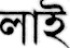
লাই
